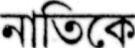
নাতিকে
